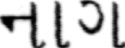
નાગ
